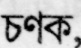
চণক,
